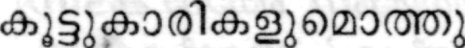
കൂട്ടുകാരികളുമൊത്തു
